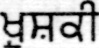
ਖ਼ੁਸ਼ਕੀ
